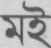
মই
